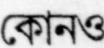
কোনও
